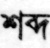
শব্দ
